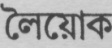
লৈয়োক
